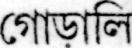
গোড়ালি
